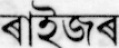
ৰাইজৰ
